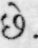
છે.
